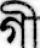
গী
